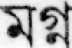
মগ্ন
